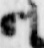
ન
